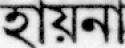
হায়না
